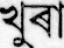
খুৰা
